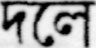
দলে
